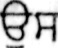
ਉਸ
